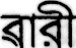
ৱারী
